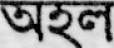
অহল
